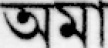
অমা
